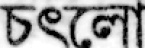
চৎলো
